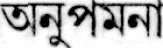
অনুপমনা
